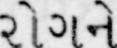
રોગને
